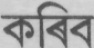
কৰিব
